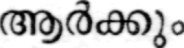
ആര്‍ക്കും
